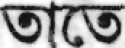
তাতে
